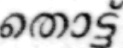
തൊട്ട്
